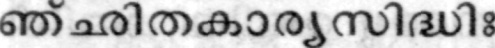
ഞ്ഛിതകാര്യസിദ്ധിഃ
